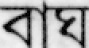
বাঘ
